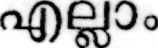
എല്ലാം
